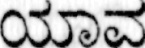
ಯಾವ
